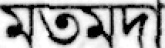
মতমদা
